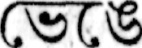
ভেঙে
